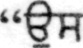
''ਉਸ
